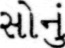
સોનું
